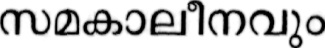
സമകാലീനവും
